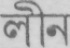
লীন
